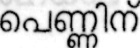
പെണ്ണിന്
